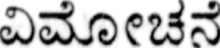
ವಿಮೋಚನೆ
